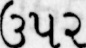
ઉપર
